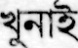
খুনাই
